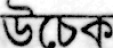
উচেক
